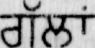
ਗੱਲਾਂ
